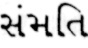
સંમતિ
